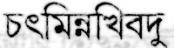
চৎমিন্নখিবদু
